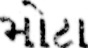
મોટા
